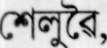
শেলুৱৈ,
